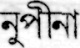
নুপীনা
